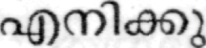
എനിക്കു
